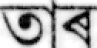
তাৰ
